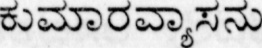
ಕುಮಾರವ್ಯಾಸನು
